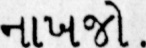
નાખજો.
